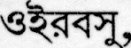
ওইরবসু,
